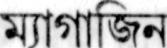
ম্যাগাজিন
